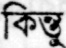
কিন্তু
